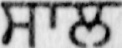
ਸਾਲ
